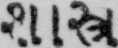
શાસ્ત્ર
